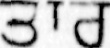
ਤਾਰ
